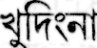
খুদিংনা
